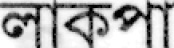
লাকপা
